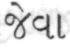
જેવા
